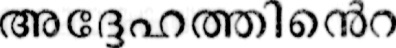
അദ്ദേഹത്തിന്റെ
